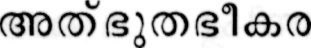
അത്ഭുതഭീകര
